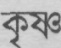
কৃষ্ণ
